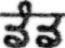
ਡੰਡ
